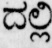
ದಲ್ಲಿ
